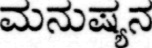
ಮನುಷ್ಯನ
